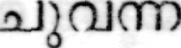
ചുവന്ന
